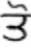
ਤੋ
